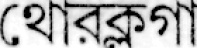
থোরক্লগা
